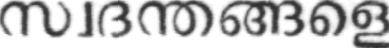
സ്വദന്തങ്ങളെ
